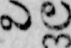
ಎಲ್ಲ
